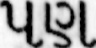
પણ
